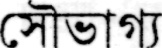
সৌভাগ্য
